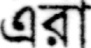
এরা
